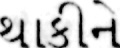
થાકીને
